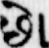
છો
